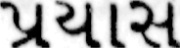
પ્રયાસ
